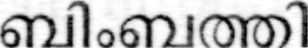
ബിംബത്തി
